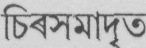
চিৰসমাদৃত
